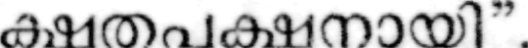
ക്ഷതപക്ഷനായി.
